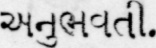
અનુભવતી.
